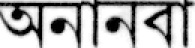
অনানবা
